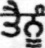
ਤੈਨੂੰ
